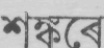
শঙ্কৰে
